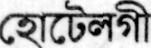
হোটেলগী
